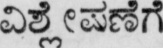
ವಿಶ್ಲೇಷಣೆಗೆ
